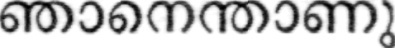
ഞാനെന്താണു
